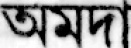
অমদা
